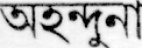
অহন্দুনা
